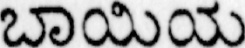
ಬಾಯಿಯ
